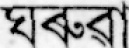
ঘৰুৱা
